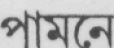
পামনে
